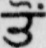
ਤੋਂ
